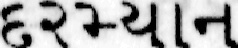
દરમ્યાન
